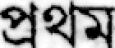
প্রথম
